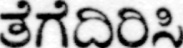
ತೆಗೆದಿರಿಸಿ
